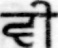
ਵੀ
